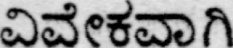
ವಿವೇಕವಾಗಿ
